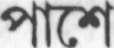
পাশে
